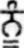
ਨੂੰ
